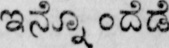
ಇನ್ನೊಂದೆಡೆ
